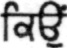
ਕਿਉਂ
